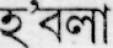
হ'বলা
